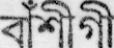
বশীগী
